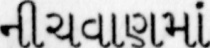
નીચવાણમાં
